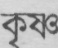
কৃষ্ণ
